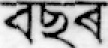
বছৰ
